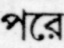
পরে
